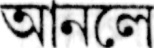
আনলে
